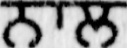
ਨਾਲ
